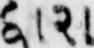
દ્વારા
